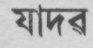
যাদৱ
